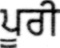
ਪੂਰੀ
